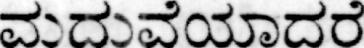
ಮದುವೆಯಾದರೆ
